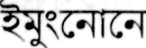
ইমুংনোনে
